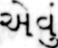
એવું
